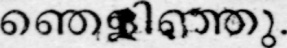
ഞെളിഞ്ഞു.
